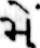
મેં
